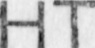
HT
